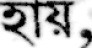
হায়,
